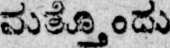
ಮತ್ತೊಂದು
